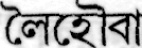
লৈহৌবা
